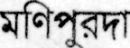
মণিপুরদা
